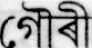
গৌৰী
